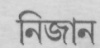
নিজান
